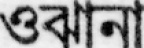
ওঝানা
